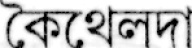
কৈথেলদা
